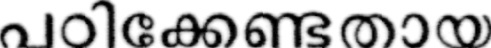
പഠിക്കേണ്ടതായ
